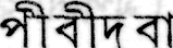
পীবীদবা
